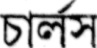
চার্লস
